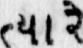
ત્યારે
